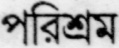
পরিশ্রম
